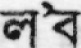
ল'ব
